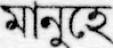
মানুহে
